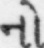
નો
